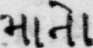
માનો
